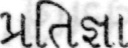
પ્રતિજ્ઞા
